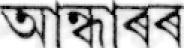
আন্ধাৰৰ
